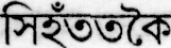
সিহঁততকৈ
